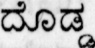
ದೊಡ್ಡ
